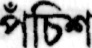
পঁচিশ
